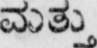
ಮತ್ತು
